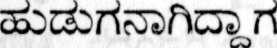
ಹುಡುಗನಾಗಿದ್ದಾಗ
